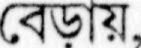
বেড়ায়,
